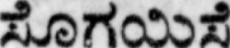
ಸೊಗಯಿಸೆ
